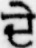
ਦੇ
